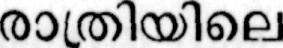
രാത്രിയിലെ
